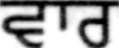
ਵਾਰ
